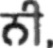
ਨੀ,
